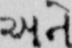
અને
